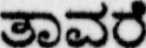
ತಾವರೆ
